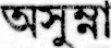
অসুম্না
